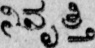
ನಿವೃತ್ತಿ
